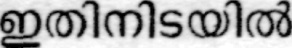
ഇതിനിടയില്‍
